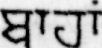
ਬਾਹਾਂ
